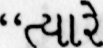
"ત્યારે
